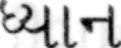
ધ્યાન
